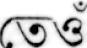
তেওঁ
